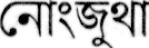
নোংজুথা
